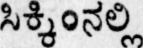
ಸಿಕ್ಕಿಂನಲ್ಲಿ
